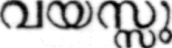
വയസ്സു
